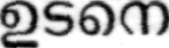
ഉടനെ
